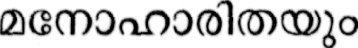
മനോഹാരിതയും
